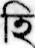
হি
